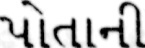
પોતાની
